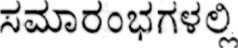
ಸಮಾರಂಭಗಳಲ್ಲಿ
